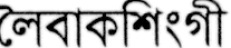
লৈবাকশিংগী
